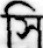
সি
